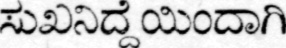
ಸುಖನಿದ್ದೆಯಿಂದಾಗಿ
